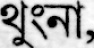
থুংনা,
